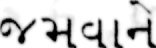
જમવાને
